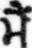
ਮੈਂ
